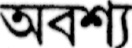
অবশ্য
